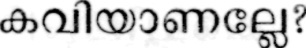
കവിയാണല്ലേ?
